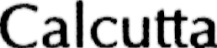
Calcutta
